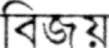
বিজয়
